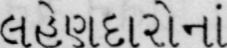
લહેણદારોનાં
